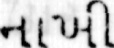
નાખી
